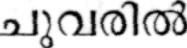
ചുവരില്‍
